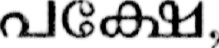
പക്ഷേ,
